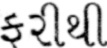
ફરીથી
